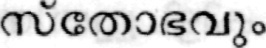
സ്തോഭവും
